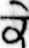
ਕੇ
